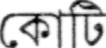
কোটি
